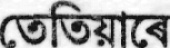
তেতিয়াৰে
